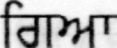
ਗਿਆ
